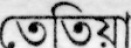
তেতিয়া
